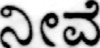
ನೀವೆ
